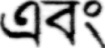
এবং
